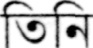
তিনি
